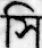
সি
